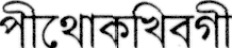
পীথোকখিবগী
